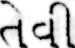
તેવી
